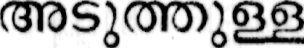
അടുത്തുള്ള
